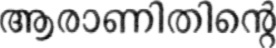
ആരാണിതിന്റെ
